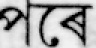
পৰে
